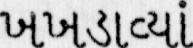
ખખડાવ્યાં
